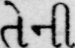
તેની
